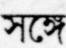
সঙ্গে
